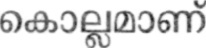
കൊല്ലമാണ്
